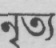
নৃত্য
